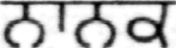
ਨਾਨਕ
